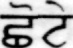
ਛੋਟੇ
